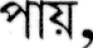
পায়,
